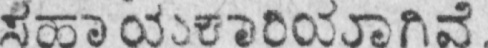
ಸಹಾಯಕಾರಿಯಾಗಿವೆ.
